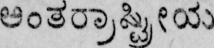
ಅಂತರ್ರಾಷ್ಟ್ರೀಯ
